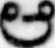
ಆ
